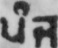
ਪੰਜ
